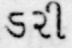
ડરી
